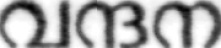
വന്ദന
